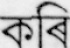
কৰি
